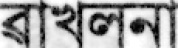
ৱাখলনা
